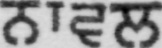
ਨਾਵਲ
